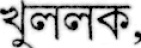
খুললক,
